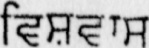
ਵਿਸ਼ਵਾਸ
